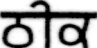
ਠੀਕ
